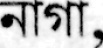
নাগা
